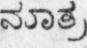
ಮಾತ್ರ
